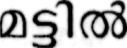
മട്ടില്‍
